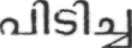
പിടിച്ച
